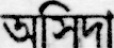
অসিদা
